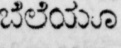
ಬೆಲೆಯೂ
